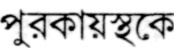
পুরকায়স্থকে
